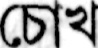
চোখ
